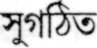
সুগঠিত
